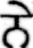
ਨੇ
